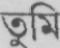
তুমি
